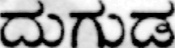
ದುಗುಡ
